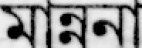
মান্ননা
